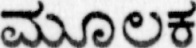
ಮೂಲಕ
